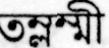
তম্লম্মী
